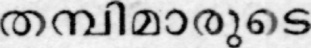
തമ്പിമാരുടെ
